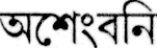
অশেংবনি
